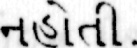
નહોતી.
